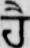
ਹੈ
